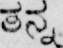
ತನ್ನ
